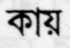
কায়
